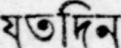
যতদিন
